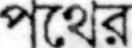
পথের
